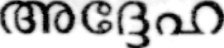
അദ്ദേഹ
